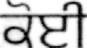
ਕੋਈ
